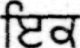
ਇਕ
